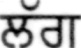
ਲੱਗ
